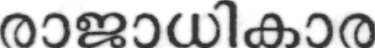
രാജാധികാര
